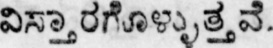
ವಿಸ್ತಾರಗೊಳ್ಳುತ್ತವೆ.
